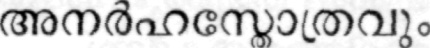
അനര്‍ഹസ്തോത്രവും
